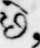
છે,
